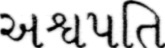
અશ્વપતિ
